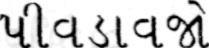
પીવડાવજો
